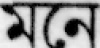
মনে
